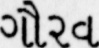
ગૌરવ
